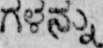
ಗಳನ್ನು
